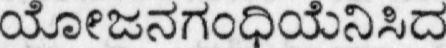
ಯೋಜನಗಂಧಿಯೆನಿಸಿದ
